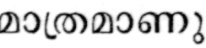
മാത്രമാണു
